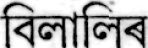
বিলালিৰ
